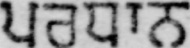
ਪਰਧਾਨ
